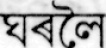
ঘৰলৈ
